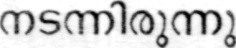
നടന്നിരുന്നു
